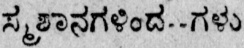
ಸ್ಮಶಾನಗಳಿಂದ..ಗಳು
